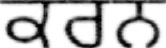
ਕਰਨ
